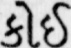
કોઈ
